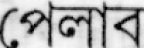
পেলাব
